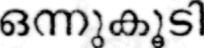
ഒന്നുകൂടി
